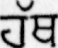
ਹੱਥ
